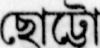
ছোট্টো
